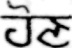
ਹੋਣ
